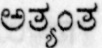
ಅತ್ಯಂತ
